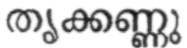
തൃക്കണ്ണു
